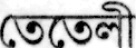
তেতেলী
